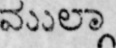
ಮುಲ್ಗಾ
